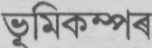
ভূমিকম্পৰ
